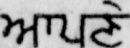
ਆਪਣੇ
